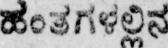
ಹಂತಗಳಲ್ಲಿನ
